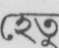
হেতু
